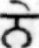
ਨੇ
